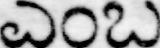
ಎಂಬ
